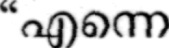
“എന്നെ
